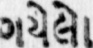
ગયેલો
